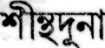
শীন্থদুনা
